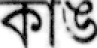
কাঙ
